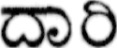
ದಾರಿ
